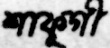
শাফূগী
